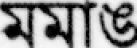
মমাঙ
